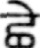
ਛੇ
